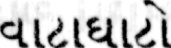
વાટાઘાટો
